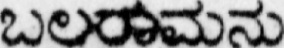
ಬಲರಾಮನು
